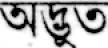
অদ্ভুত
